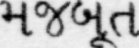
મજબૂત
